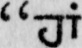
''ਹਾਂ
